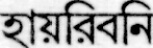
হায়রিবনি
